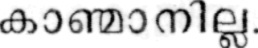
കാണ്മാനില്ല.
